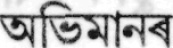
অভিমানৰ
